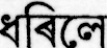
ধৰিলে
